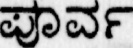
ಪೂರ್ವ
